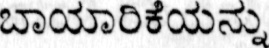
ಬಾಯಾರಿಕೆಯನ್ನು
